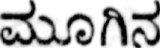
ಮೂಗಿನ
